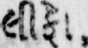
લીફો.
